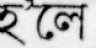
হ'লে
